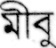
মীবু
